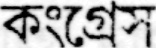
কংগ্রেস
